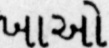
ખાઓ
